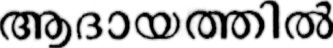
ആദായത്തില്‍
